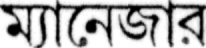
ম্যানেজার
